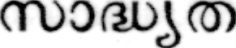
സാദ്ധ്യത
